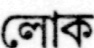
লোক
